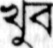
খুব
